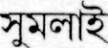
সুমলাই
